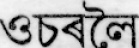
ওচৰলৈ
